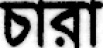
চারা
